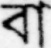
বা
